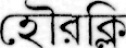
হৌরক্লি
